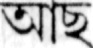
আছ
